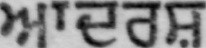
ਆਦਰਸ਼
